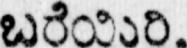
ಬರೆಯಿರಿ.
